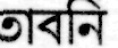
তাবনি
